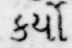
કર્યો
